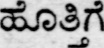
ಹೊತ್ತಿಗೆ
